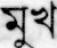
মুখ
